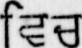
ਵਿਚ
